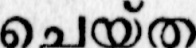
ചെയ്ത
